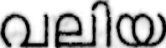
വലിയ
